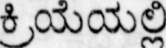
ಕ್ರಿಯೆಯಲ್ಲಿ
